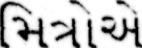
મિત્રોએ
